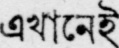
এখানেই
